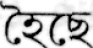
হৈছে
